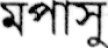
মপাসু
